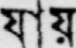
যায়
